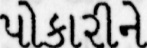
પોકારીને
